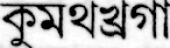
কুমথখ্রগা
